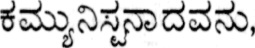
ಕಮ್ಯುನಿಸ್ಟನಾದವನು,
